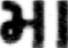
મા
